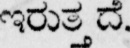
ಇರುತ್ತದೆ.
